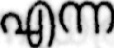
എന്ന
